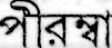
পীরম্বা
